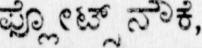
ಫ್ಲೋಟ್ಸ್ನೌಕೆ,
